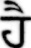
ਹੈ
